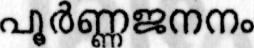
പൂര്‍ണ്ണജനനം
